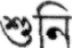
শুনি
